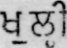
ਖੁਲ੍ਹੀ
